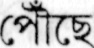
পৌঁছে
